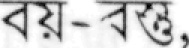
বয়-বস্তু,
